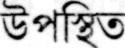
উপস্থিত
